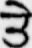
ਤੇ
